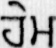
ਹੇਮ
